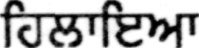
ਹਿਲਾਇਆ
